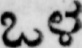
ಒಳ
